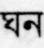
ঘন
